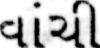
વાંચી
